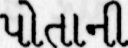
પોતાની
